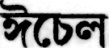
ঈচেল
